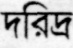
দরিদ্র
